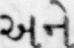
અને
